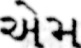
એમ
